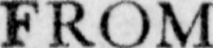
FROM
